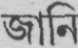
জানি
